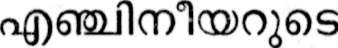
എഞ്ചിനീയറുടെ
